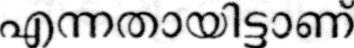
എന്നതായിട്ടാണ്
